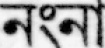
নংনা
